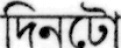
দিনটো
